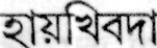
হায়খিবদা
